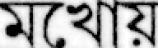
মখোয়
